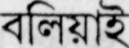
বলিয়াই
